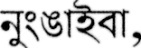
নুংঙাইবা,
